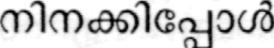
നിനക്കിപ്പോള്‍
